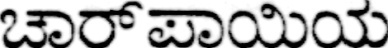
ಚಾರ್ಪಾಯಿಯ
